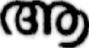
ആ
